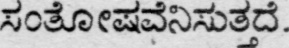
ಸಂತೋಷವೆನಿಸುತ್ತದೆ.
